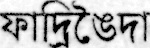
ফাদ্রিঙৈদা
